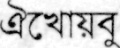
ঐখোয়বু
